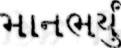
માનભર્યું
